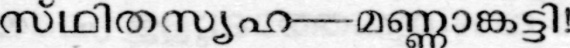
സ്ഥിതസ്യഹ-മണ്ണാങ്കട്ടി!
